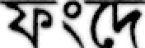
ফংদে
